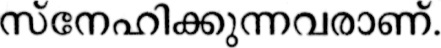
സ്നേഹിക്കുന്നവരാണ്.
